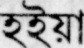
হইয়া
